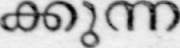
ക്കുന്ന
